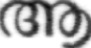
ആ
